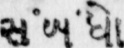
સંબંધો
